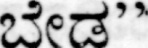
ಬೇಡ"
